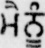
ਮੈਨੂੰ
